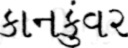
કાનકુંવર
